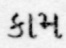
કામ
